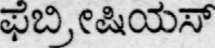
ಫೆಬ್ರೀಷಿಯಸ್
